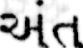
અંત
